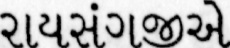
રાયસંગજીએ
